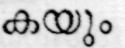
കയും
